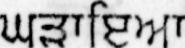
ਘੜਾਇਆ
